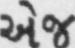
એજ
